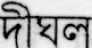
দীঘল
